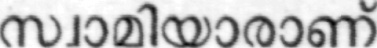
സ്വാമിയാരാണ്
